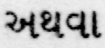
અથવા
